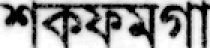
শকফমগা
